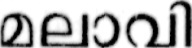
മലാവി
